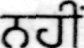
ਨਹੀਂ
